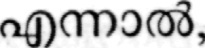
എന്നാല്‍,
